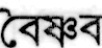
বৈষ্ণব
